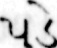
પડે
